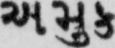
અમુક
